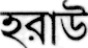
হরাউ
